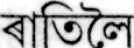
ৰাতিলৈ
